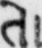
તો
